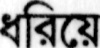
ধরিয়ে
